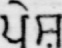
ਪੇਸ਼
